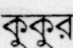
কুকুর
